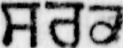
ਸਰਕ
